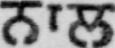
ਨਾਲ
